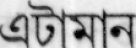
এটামান
